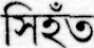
সিহঁত
